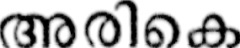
അരികെ
